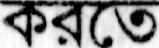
করতে
